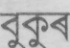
বুকুৰ
